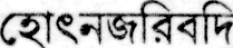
হোৎনজরিবদি
